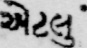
એટલું
